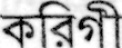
করিগী
